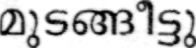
മുടങ്ങീട്ടു
